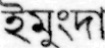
ইমুংদা
